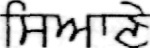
ਸਿਆਣੇ
